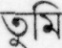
তুমি
